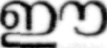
ഈ
